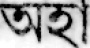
অহা
